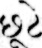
છૂટે
